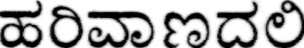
ಹರಿವಾಣದಲಿ
